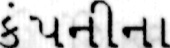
કંપનીના
